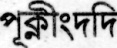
পূক্নীংদদি
